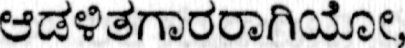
ಆಡಳಿತಗಾರರಾಗಿಯೋ,
